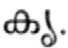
കൃ.
